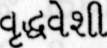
વૃદ્ધવેશી
